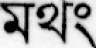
মথং
